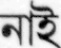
নাই
